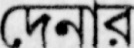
দেনার
